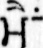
ਮੈਂ
